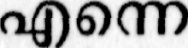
എന്നെ
